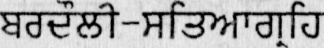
ਬਰਦੌਲੀ-ਸਤਿਆਗ੍ਰਹਿਛ
